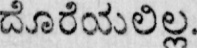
ದೊರೆಯಲಿಲ್ಲ.
